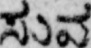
ಸುವ
